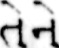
તેને
